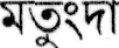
মতুংদা
